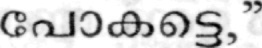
പോകട്ടെ,"
